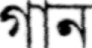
গান
